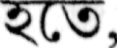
হতে,
